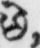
છે,
